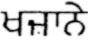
ਖਜ਼ਾਨੇ
